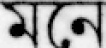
মনে
